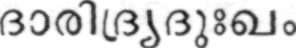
ദാരിദ്ര്യദുഃഖം
